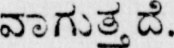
ವಾಗುತ್ತದೆ.
